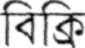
বিক্রি
